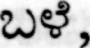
ಬಳೆ,
